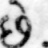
છે.
